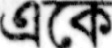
একে
